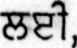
ਲਈ,
